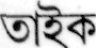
তাইক
